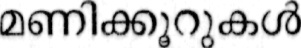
മണിക്കൂറുകള്‍
